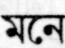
মনে
